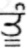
ਤੂੰ
